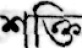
শক্তি
